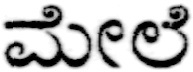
ಮೇಲೆ
